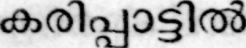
കരിപ്പാട്ടില്‍
